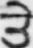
ਤੇ
